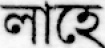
লাহে
